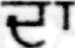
ਦਾ
